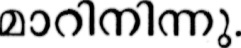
മാറിനിന്നു.
